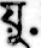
য়ু.
